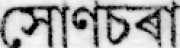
সোণচৰা
